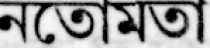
নতোমতা
